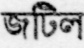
জটিল
